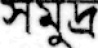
সমুদ্র
